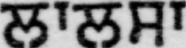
ਲਾਲਸਾ
